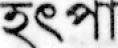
হৎপা
